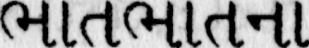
ભાતભાતના
